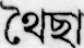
থৈছা
